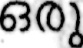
ഒരു
